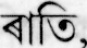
ৰাতি,
